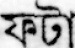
ফটা
